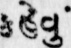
કહેવું
